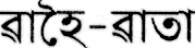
ৱাহৈ-ৱাতা
